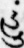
હું
